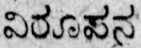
ವಿರೂಪನ
